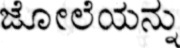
ಜೋಲೆಯನ್ನು
